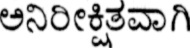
ಅನಿರೀಕ್ಷಿತವಾಗಿ
